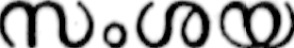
സംശയ
